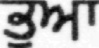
ਭੁਆ
